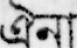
ঐনা
